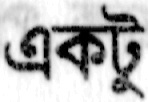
একটু
